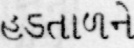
હડતાળને
